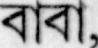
বাবা,
